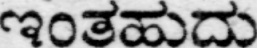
ಇಂತಹುದು
